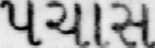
પચાસ
